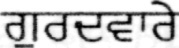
ਗੁਰਦਵਾਰੇ
